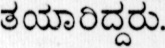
ತಯಾರಿದ್ದರು.
